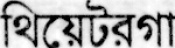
থিয়েটরগা
